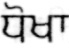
ਧੋਖਾ
